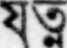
যত্ন
